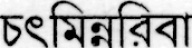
চৎমিন্নরিবা
